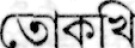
তোকখি
